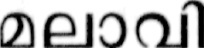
മലാവി
